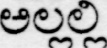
ಅಲ್ಲಲ್ಲಿ
